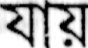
যায়
